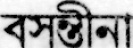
বসন্তীনা
